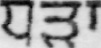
ਧੜਾ
